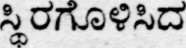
ಸ್ಥಿರಗೊಳಿಸಿದ
